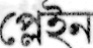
প্লেইন
